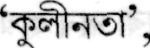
‘কুলীনতা’,
